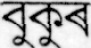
বুকুৰ
